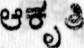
ಆಕೃತಿ
